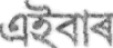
এইবাৰ
